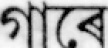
গাৰে
